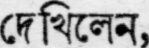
দেখিলেন,
